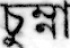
চুম্না
